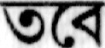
তবে
